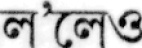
ল'লেও
